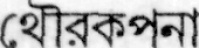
থৌরকপনা
